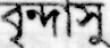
বৃন্দাসু
